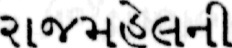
રાજમહેલની
